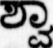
ಶ್ವಾ
